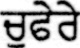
ਚੁਫੇਰੇ
